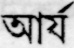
আর্য
